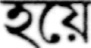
হয়ে
